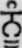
ਨੂੰ
